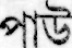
পাউ
